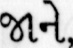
જાને,
